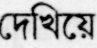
দেখিয়ে
